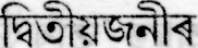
দ্বিতীয়জনীৰ
